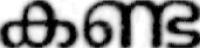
കണ്ട
